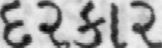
દરકાર
